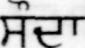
ਸੌਦਾ
